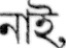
নাই,
